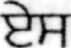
ਏਸ
